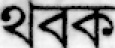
থবক
